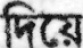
দিয়ে
